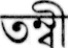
তম্বী
